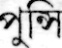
পুন্সি
